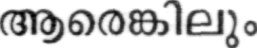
ആരെങ്കിലും
